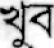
খুব
